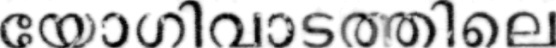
യോഗിവാടത്തിലെ
